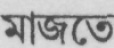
মাজতে
